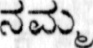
ನಮ್ಮ
